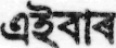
এইবাৰ
